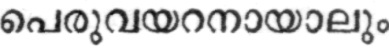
പെരുവയറനായാലും
